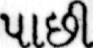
પાછી
